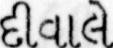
દીવાલે
